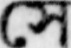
সে
